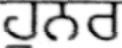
ਹੁਨਰ
